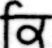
ਕਿ
